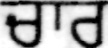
ਚਾਰ
